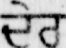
ਦੇਰ
